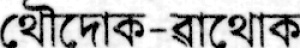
থৌদোক-ৱাথোক
